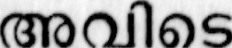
അവിടെ
